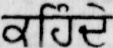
ਕਹਿੰਦੇ
